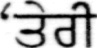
'ਤੇਰੀ
